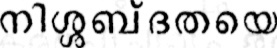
നിശ്ശബ്ദതയെ
